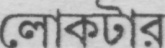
লোকটার
